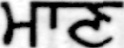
ਮਾਣ
